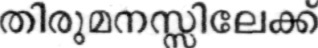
തിരുമനസ്സിലേക്ക്
